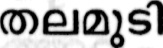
തലമുടി
